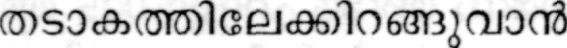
തടാകത്തിലേക്കിറങ്ങുവാന്‍
